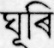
ঘূৰি
